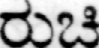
ರುಚಿ
